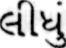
લીધું
